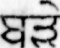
ਬੜੇ
